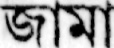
জামা
